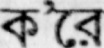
ক'রে
